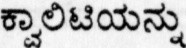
ಕ್ವಾಲಿಟಿಯನ್ನು
